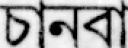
চানবা
